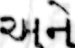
અને
